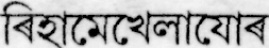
ৰিহামেখেলাযোৰ
